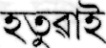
হতুৱাই
